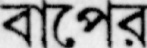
বাপের
